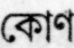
কোণ
